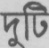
দুটি
